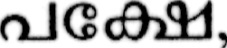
പക്ഷേ,
